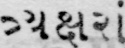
ત્યક્ષરાં
